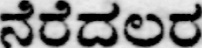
ನೆರೆದಲರ
